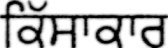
ਕਿੱਸਾਕਾਰ
